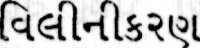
વિલીનીકરણ
